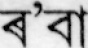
ৰ'বা
